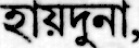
হায়দুনা,
